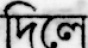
দিলে
